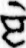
ਏ
